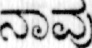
ನಾವು
